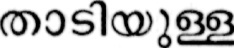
താടിയുള്ള
